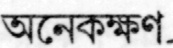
অনেকক্ষণ
